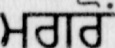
ਮਗਰੋਂ
